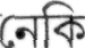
নেকি
